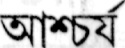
আশ্চর্য
